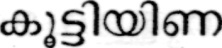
കൂട്ടിയിണ
